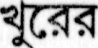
খুরের
